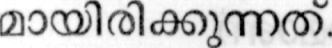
മായിരിക്കുന്നത്.
